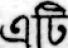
এটি
